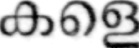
കളെ
